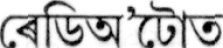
ৰেডিঅ'টোত
